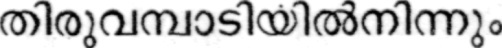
തിരുവമ്പാടിയില്‍നിന്നും
